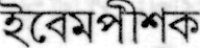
ইবেমপীশক
